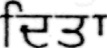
ਦਿਤਾ
